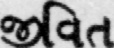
જીવિત
